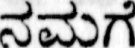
ನಮಗೆ
